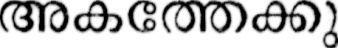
അകത്തേക്കു
